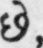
છે,
